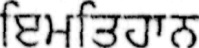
ਇਮਤਿਹਾਨ
